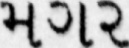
મગર
